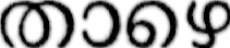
താഴെ
